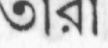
তারা
